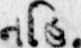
નહિ.
